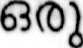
ഒരു
